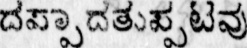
ದಪ್ಪಾದತುಪ್ಪಟವು
